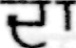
ਦਾ
